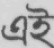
এই
